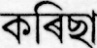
কৰিছা
